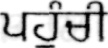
ਪਹੁੰਚੀ
